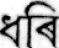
ধৰি
